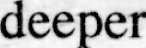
deeper
